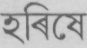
হৰিষে
